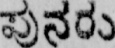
ಪುನರು
